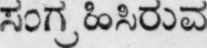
ಸಂಗ್ರಹಿಸಿರುವ
